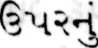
ઉપરનું
